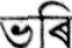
ভৰি
